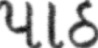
પાઠ
